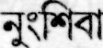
নুংশিবা
